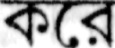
করে
